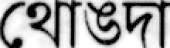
থোঙদা
